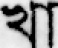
খা
